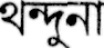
থন্দুনা
